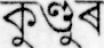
কুণ্ডুৰ
